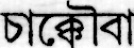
চাক্কৌবা
